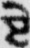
ਏ
